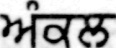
ਅੰਕਲ
